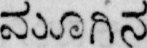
ಮೂಗಿನ
